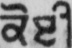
ਕੋਈ
